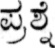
ಪ್ರಶ್ನೆ
